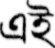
এই
